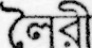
লৈরী
